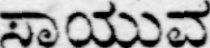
ಸಾಯುವ
